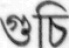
গুচি
